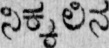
ನಿಕ್ಕಲಿನ
